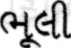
ભૂલી
